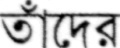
তাঁদের
